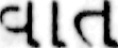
વાત
